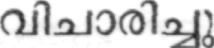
വിചാരിച്ചു
